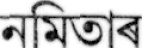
নমিতাৰ
